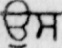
ਉਸ
